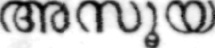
അസൂയ
